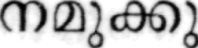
നമുക്കു
